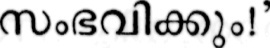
സംഭവിക്കും!'
